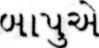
બાપુએ
